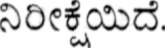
ನಿರೀಕ್ಷೆಯಿದೆ.
